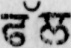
ਫੁੱਲ
